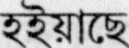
হইয়াছে
